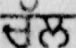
ਚੱਲ
